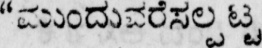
“ಮುಂದುವರೆಸಲ್ಪಟ್ಟ
